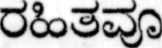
ರಹಿತವೂ
